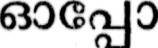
ഓപ്പോ
